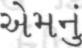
એમનું
